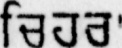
ਚਿਹਰਾ
